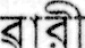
ৱারী
